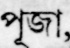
পূজা,
